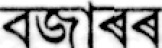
বজাৰৰ
